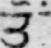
ਤੋਂ
